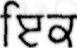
ਇਕ
